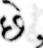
છે,
